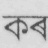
কৰ
